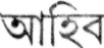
আহিব
